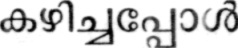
കഴിച്ചപ്പോള്‍
